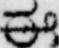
ಈ
